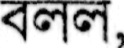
বলল,
